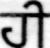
ਹੀ
